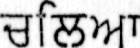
ਚਲਿਆ
